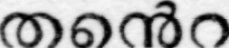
തന്റെ
